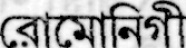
রোমোনিগী
